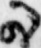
જે
